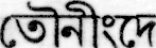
তৌনীংদে
